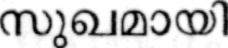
സുഖമായി
